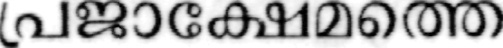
പ്രജാക്ഷേമത്തെ
